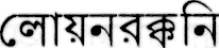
লোয়নরক্কনি
